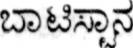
ಬಾಟಿಸ್ಟಾನ
